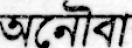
অনৌবা
